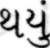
થયું
